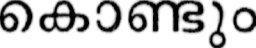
കൊണ്ടും
